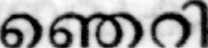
ഞെറി
